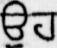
ਉਹ
